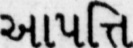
આપત્તિ
